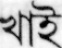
খাই
